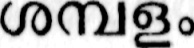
ശമ്പളം
